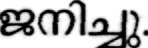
ജനിച്ചു.
